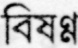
বিষণ্ণ
